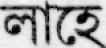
লাহে
